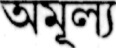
অমূল্য
